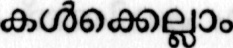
കള്‍ക്കെല്ലാം
